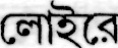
লোইরে
